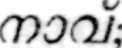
നാവ്;
